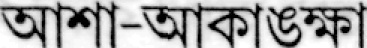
আশা-আকাঙক্ষা
